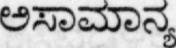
ಅಸಾಮಾನ್ಯ
